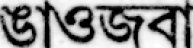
ঙাওজবা
